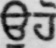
ਉਹੋ
